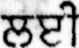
ਲਈ
